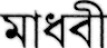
মাধবী
